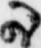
જે
